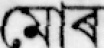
মোৰ
